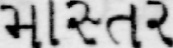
માસ્તર
